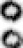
ঃ
